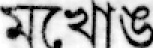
মখোঙ
